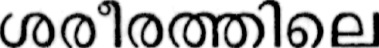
ശരീരത്തിലെ
